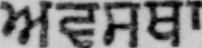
ਅਵਸਥਾ
